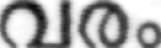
വരം
